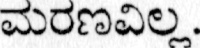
ಮರಣವಿಲ್ಲ.
